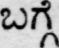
ಬಗ್ಗೆ
